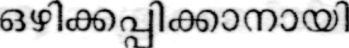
ഒഴിക്കപ്പിക്കാനായി
